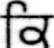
ਕਿ
